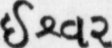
ઇશ્વર
